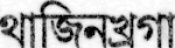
থাজিনখ্রগা
